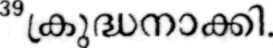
39ക്രുദ്ധനാക്കി.
